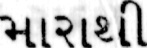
મારાથી
